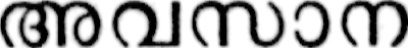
അവസാന
